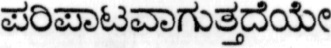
ಪರಿಪಾಟವಾಗುತ್ತದೆಯೇ
